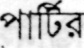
পার্টির
